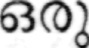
ഒരു
